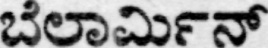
ಬೆಲಾರ್ಮಿನ್
